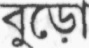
বুড়ো
